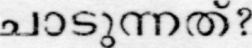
ചാടുന്നത്?
